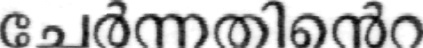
ചേര്‍ന്നതിന്റെ
